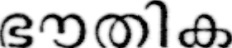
ഭൌതിക
